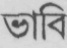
ভাবি
